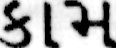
કામ
